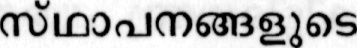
സ്ഥാപനങ്ങളുടെ
